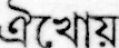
ঐখোয়
